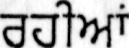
ਰਹੀਆਂ
